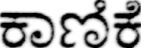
ಕಾಣಿಕೆ
